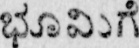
ಭೂಮಿಗೆ
